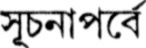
সূচনাপর্বে
